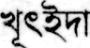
খূৎইদা
